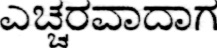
ಎಚ್ಚರವಾದಾಗ
